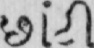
છાંટિ
